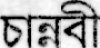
চান্নবী
